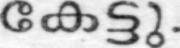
കേട്ടു.
